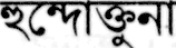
হুন্দোক্তুনা
